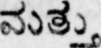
ಮತ್ತು
